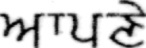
ਆਪਣੇ
